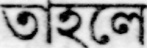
তাহলে
